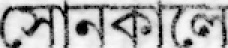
সোনকালে
